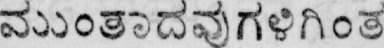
ಮುಂತಾದವುಗಳಿಗಿಂತ
